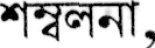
শম্বলনা,
